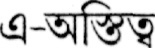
এ-অস্তিত্ব
